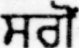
ਸਗੋਂ
